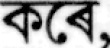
কৰে,
